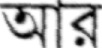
আর
